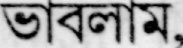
ভাবলাম,
